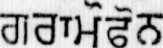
ਗਰਾਮੋਫੋਨ
